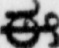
ಈ
